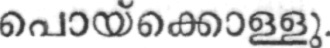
പൊയ്ക്കൊള്ളു.
